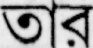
তার
